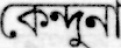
কেন্দুনা
